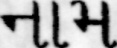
નામ
